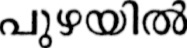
പുഴയില്‍
